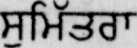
ਸੁਮਿੱਤਰਾ
